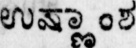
ಉಷ್ಣಾಂಶ
